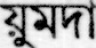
য়ুমদা
